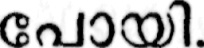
പോയി.
